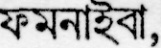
ফমনাইবা,
